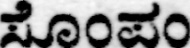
ಸೊಂಪಂ
